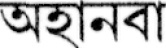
অহানবা
